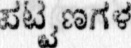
ಪಟ್ಟಣಗಳ
